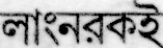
লাংনরকই
